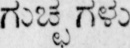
ಗುಚ್ಛಗಳು
